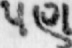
પણ
